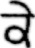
ਕੇ
